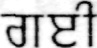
ਗਈ
